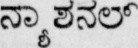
ನ್ಯಾಶನಲ್
